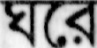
ঘরে
